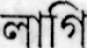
লাগি
